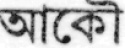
আকৌ
